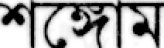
শঙ্গোম
